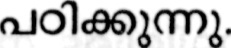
പഠിക്കുന്നു.
